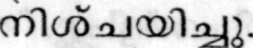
നിശ്ചയിച്ചു.
